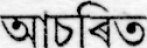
আচৰিত
